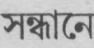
সন্ধানে
